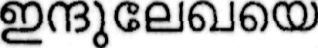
ഇന്ദുലേഖയെ
